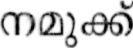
നമുക്ക്
